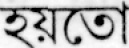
হয়তো
